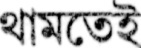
থামতেই
